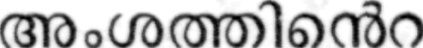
അംശത്തിന്റെ
